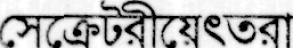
সেক্রেটরীয়েৎতরা
